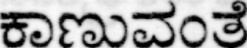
ಕಾಣುವಂತೆ
